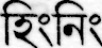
হিংনিং
